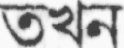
তখন
